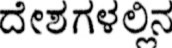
ದೇಶಗಳಲ್ಲಿನ
